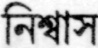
নিশ্বাস
